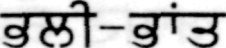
ਭਲੀ-ਭਾਂਤ
